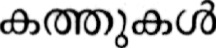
കത്തുകള്‍
